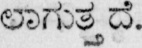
ಲಾಗುತ್ತದೆ.
